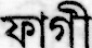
ফাগী
